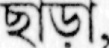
ছাড়া,
